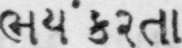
ભયંકરતા
